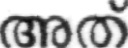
അത്
